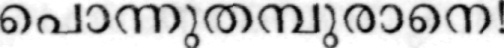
പൊന്നുതമ്പുരാനെ!
